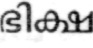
ഭിക്ഷ
